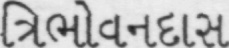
ત્રિભોવનદાસ
